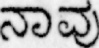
ನಾವು
